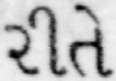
રીતે
